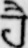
ਹੈ
